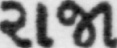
રાજા
